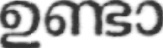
ഉണ്ടാ
